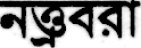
নত্ত্রবরা
